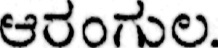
ಆರಂಗುಲ.
